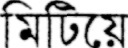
মিটিয়ে
